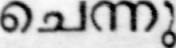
ചെന്നു
